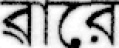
ৱারে
